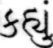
કહ્યું
